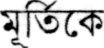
মূর্তিকে
